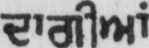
ਦਾਗੀਆਂ
